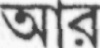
আর
